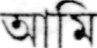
আমি
